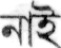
নাই
